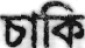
চাকি
